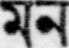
মন
